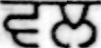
ਵਲ
